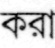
করা
